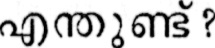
എന്തുണ്ട്?
